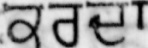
ਕਰਦਾ
